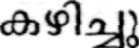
കഴിച്ചു
